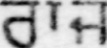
ਰਾਜ
